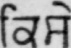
ਕਿਸੇ
